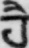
ਹੈ
